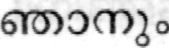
ഞാനും
